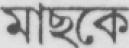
মাছকে
